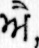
ਐ,
